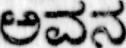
ಅವನ
